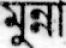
মুন্না
